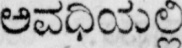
ಅವಧಿಯಲ್ಲಿ
